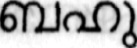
ബഹു
